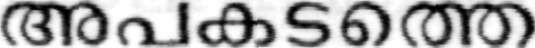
അപകടത്തെ
